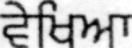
ਵੇਖਿਆ
